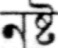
নষ্ট
